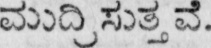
ಮುದ್ರಿಸುತ್ತವೆ.
